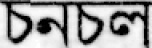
চনচল
